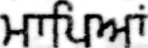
ਮਾਪਿਆਂ
